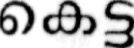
കെട്ട
